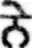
ਨੇ
